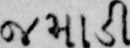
જમાડી
